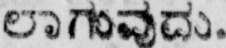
ಲಾಗುವುದು.
